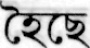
হৈছে
